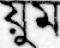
য়ুম
